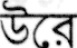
উরে
